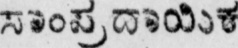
ಸಾಂಪ್ರದಾಯಿಕ
